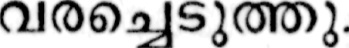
വരച്ചെടുത്തു.
